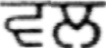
ਵਲ
